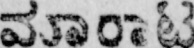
ಮಾರಾಟ
